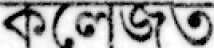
কলেজত
